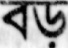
বড়
